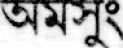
অমসুং
